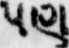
પણ
